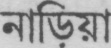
নাড়িয়া
